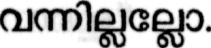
വന്നില്ലല്ലോ.
